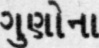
ગુણોના
